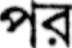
পর
